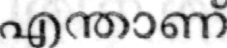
എന്താണ്
